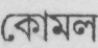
কোমল
